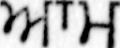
ਆਮ
